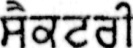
ਸੈਕਟਰੀ
